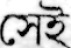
সেই
